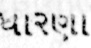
ધારણા
